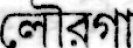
লৌরগা
